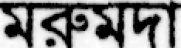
মরুমদা
